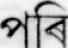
পৰি
